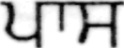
ਪਾਸ
